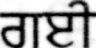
ਗਈ
